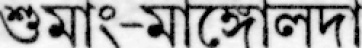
শুমাং-মাঙ্গোলদা
